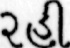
રહી
